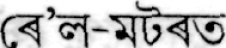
ৰে'ল-মটৰত
